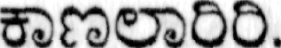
ಕಾಣಲಾರಿರಿ.
